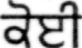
ਕੋਈ
